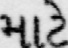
માટે
